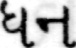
ધન
